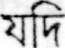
যদি
